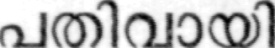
പതിവായി
